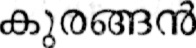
കുരങ്ങന്‍
